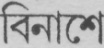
বিনাশে
